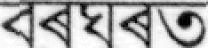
বৰঘৰত
